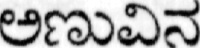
ಅಣುವಿನ
